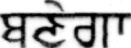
ਬਣੇਗਾ
